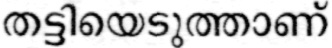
തട്ടിയെടുത്താണ്
